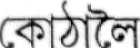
কোঠালৈ
